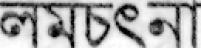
লমচৎনা
